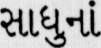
સાધુના
